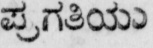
ಪ್ರಗತಿಯು
